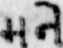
મને
